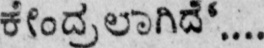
ಕೇಂದ್ರಲಾಗಿದೆ....
